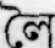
লৈ
